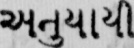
અનુયાયી
